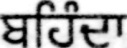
ਬਹਿੰਦਾ
